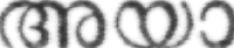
അയാ
